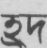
হ্ৰদ
